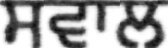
ਸਵਾਲ
